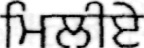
ਮਿਲੀਏ
